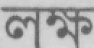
লক্ষ
